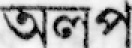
অলপ
